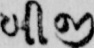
બીજી
